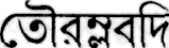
তৌরম্লবদি
